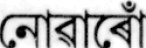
নোৱাৰোঁ
